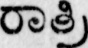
ರಾತ್ರಿ
